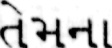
તેમના
